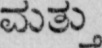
ಮತ್ತು
